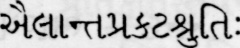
ઐલાન્તપ્રકટશ્રુતિઃ
